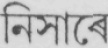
নিসাৰে
